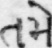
તમે
